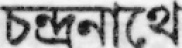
চন্দ্রনাথে
